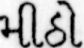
મીઠો
